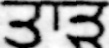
ਤਾੜ
